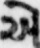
એ
